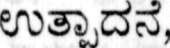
ಉತ್ಪಾದನೆ,
